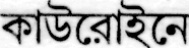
কাউরোইনে
